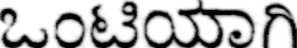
ಒಂಟಿಯಾಗಿ
